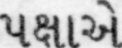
પક્ષાએ
